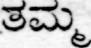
ತಮ್ಮ
